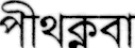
পীথক্নবা
